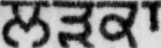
ਲੜਕਾ
